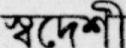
স্বদেশী
